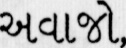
અવાજો,
